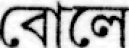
বোলে
